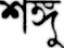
শঙ্গু
